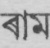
ৰাম
